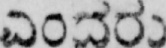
ಎಂದರು
